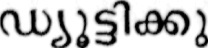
ഡ്യൂട്ടിക്കു
